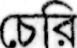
চেরি
